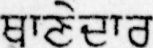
ਥਾਣੇਦਾਰ
